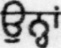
ਉਨ੍ਹਾਂ
